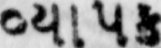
વ્યાપક
